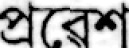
প্রৱেশ
